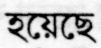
হয়েছে
